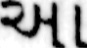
આ
